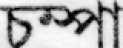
চম্পা
